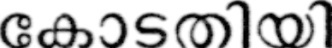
കോടതിയി
